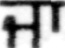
ਜਾ
